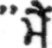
''ਮੈਂ
